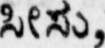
ಸೀಸು,
